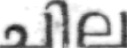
ചില
